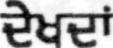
ਦੇਖਦਾਂ
